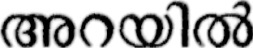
അറയില്‍
